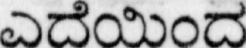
ಎದೆಯಿಂದ
